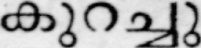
കുറച്ചു
